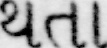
થતા
